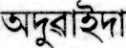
অদুৱাইদা
